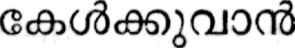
കേള്‍ക്കുവാന്‍
